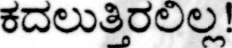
ಕದಲುತ್ತಿರಲಿಲ್ಲ!
